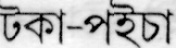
টকা-পইচা
